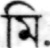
মি.
